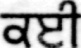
ਕਈ
